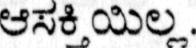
ಆಸಕ್ತಿಯಿಲ್ಲ.
